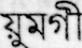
য়ুমগী
